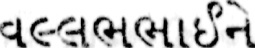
વલ્લભભાઈને
